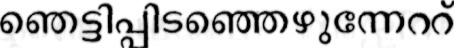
ഞെട്ടിപ്പിടഞ്ഞെഴുന്നേററ്
